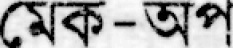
মেক-অপ
